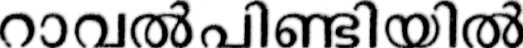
റാവല്‍പിണ്ടിയില്‍
